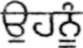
ਉਹਨੂੰ
